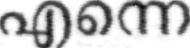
എന്നെ
